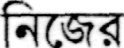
নিজের
